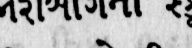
હજારીબાગની
